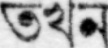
তখন
